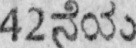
42ನೆಯ
